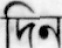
দিন
